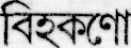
বিহকণো
